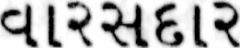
વારસદાર
